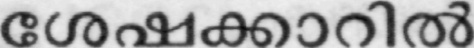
ശേഷക്കാറില്‍
